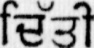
ਦਿੱਤੀ
